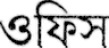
ওফিস
